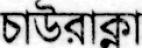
চাউরাক্না
